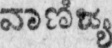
ವಾಣಿಜ್ಯ
